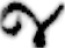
જ
